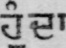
ਹੁੰਦਾ
